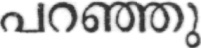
പറഞ്ഞു
